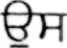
ਉਸ
